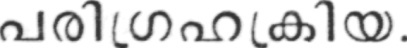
പരിഗ്രഹക്രിയ.
